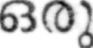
ഒരു
